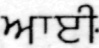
ਆਈ
